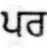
ਪਰ
